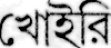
খোইরি
